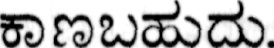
ಕಾಣಬಹುದು.
